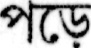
পড়ে
